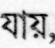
যায়,
